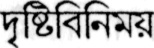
দৃষ্টিবিনিময়
